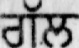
ਗੱਲ
